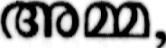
അമ്മ,
